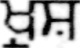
ਖ਼ੁਸ਼
